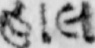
હાલ
